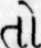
તો
